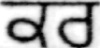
ਕਰ
